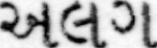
અલગ
